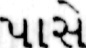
પાસે
